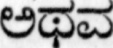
ಅಥವ
